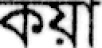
কয়া
